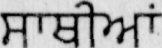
ਸਾਥੀਆਂ
